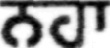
ਨਹਾ
